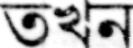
তখন
